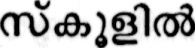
സ്കൂളില്‍
